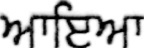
ਆਇਆ
